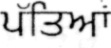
ਪੱਤਿਆਂ
